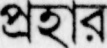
প্রহার
